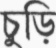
চুড়ি
